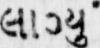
લાગ્યું
